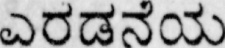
ಎರಡನೆಯ
